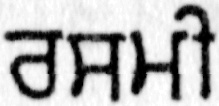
ਰਸਮੀ
